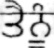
ਤੈਨੂੰ
